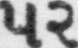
પર
